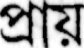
প্রায়
